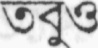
তবুও
